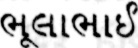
ભૂલાભાઈ
